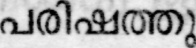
പരിഷത്തു
